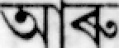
আৰু
